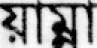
য়াম্না
